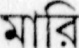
মারি
